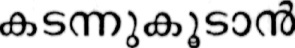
കടന്നുകൂടാന്‍
